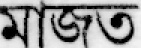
মাজত
